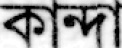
কান্দা
